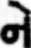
ને
